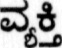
ವ್ಯಕ್ತಿ
